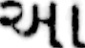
આ
